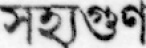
সহ্যগুণ
